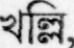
খল্লি,
